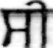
ਸੀ
